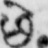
છે.
